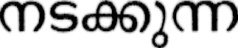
നടക്കുന്ന
